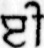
ਈ
